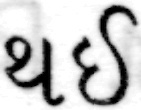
થઈ
